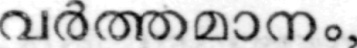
വര്‍ത്തമാനം,
